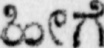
ಹೀಗೆ
